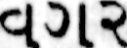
વગર
